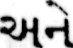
અને
